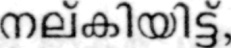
നല്കിയിട്ട്,
